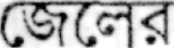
জেলের
